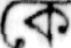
কে
